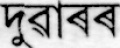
দুৱাৰৰ
